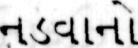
નડવાનો
